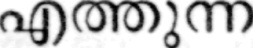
എത്തുന്ന
